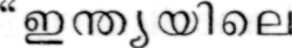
"ഇന്ത്യയിലെ
